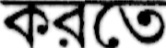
করতে
